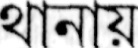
থানায়
